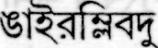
ঙাইরম্লিবদু
